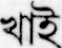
খাই
